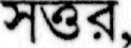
সত্তর,
